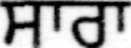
ਸਾਰਾ
